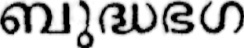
ബുദ്ധഭഗ
